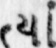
ત્યાં
